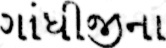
ગાંધીજીના
